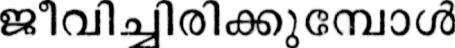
ജീവിച്ചിരിക്കുമ്പോള്‍
